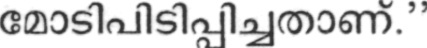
മോടിപ്പിടിപ്പിച്ചതാണ്."
